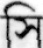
সি
